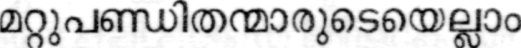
മറ്റുപണ്ഡിതന്മാരുടെയെല്ലാം
